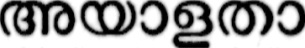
അയാളതാ
